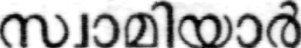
സ്വാമിയാര്‍
